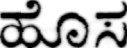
ಹೊಸ
